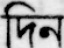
দিন
